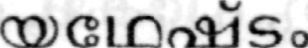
യഥേഷ്ടം
